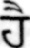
ਹੈ
